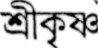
শ্রীকৃষ্ণ
